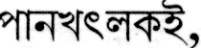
পানখৎলকই,
